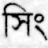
সিং
